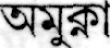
অমুক্না
